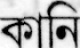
কানি
